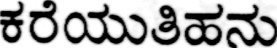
ಕರೆಯುತಿಹನು
